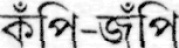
কঁপি-জঁপি
